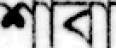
শাবা
